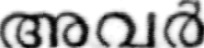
അവര്‍
